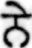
ਨੇ
